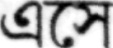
এসে
